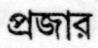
প্রজার
